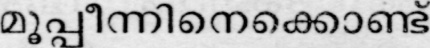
മൂപ്പീന്നിനെക്കൊണ്ട്
